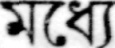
মধ্যে
